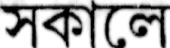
সকালে
